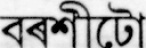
বৰশীটো
